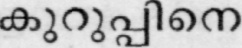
കുറുപ്പിനെ
